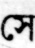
সে
